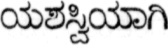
ಯಶಸ್ವಿಯಾಗಿ
